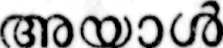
അയാള്‍
